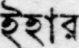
ইহার
